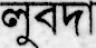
লুবদা
